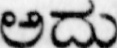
ಅದು
